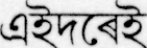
এইদৰেই
